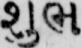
શુભ
